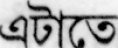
এটাতে
